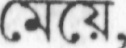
মেয়ে,
